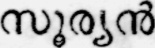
സൂര്യന്‍
